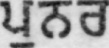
ਪੁਨਰ
